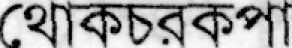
থোকচরকপা
